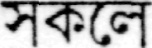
সকলে
